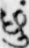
છું
